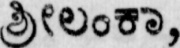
ಶ್ರೀಲಂಕಾ,
